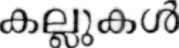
കല്ലുകള്‍
